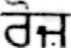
ਰੋਜ਼
